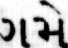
ગમે
